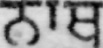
ਨਾਥ
